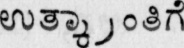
ಉತ್ಕ್ರಾಂತಿಗೆ
